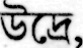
উদ্রে,
